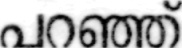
പറഞ്ഞ്
